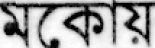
মকোয়
